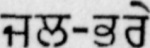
ਜਲ-ਭਰੇ
